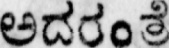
ಅದರಂತೆ
